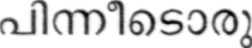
പിന്നീടൊരു
